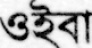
ওইবা
